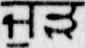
ਜੁੜ
